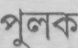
পুলক
